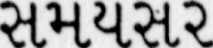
સમયસર
